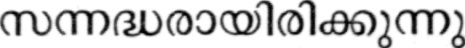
സന്നദ്ധരായിരിക്കുന്നു
